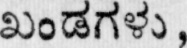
ಖಂಡಗಳು,
